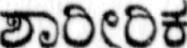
ಶಾರೀರಿಕ
